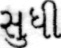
સુધી
